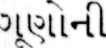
ગૂણોની
